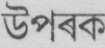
উপৰক
